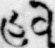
હવે
